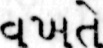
વખતે
